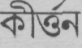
কীৰ্ত্তন
